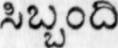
ಸಿಬ್ಬಂದಿ
